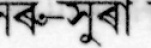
সৰু-সুৰা
